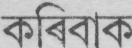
কৰিবাক
